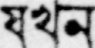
যখন
